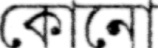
কোনো
